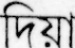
দিয়া
